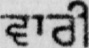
ਵਾਰੀ
